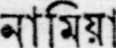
নামিয়া
